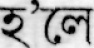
হ'লে
